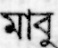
মাবু
